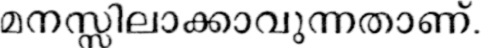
മനസ്സിലാക്കാവുന്നതാണ്.
